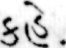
કહે.
